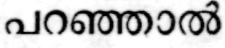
പറഞ്ഞാല്‍
